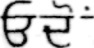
ਓਦੋਂ
